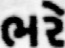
ભરે
